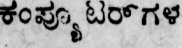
ಕಂಪ್ಯೂಟರ್‌ಗಳ
